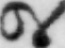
જ
